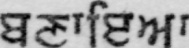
ਬਣਾਇਆ
